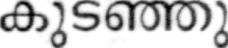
കുടഞ്ഞു
